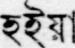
হইয়া
